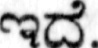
ಇದೆ.
